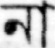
না
